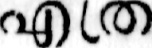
എത്ര
